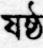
ষষ্ঠ
